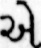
એ
